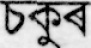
চকুৰ
